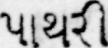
પાથરી
